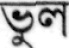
ভুল
